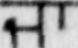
ਜਾ
